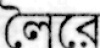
লৈরে
